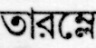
তারম্লে
